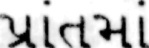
પ્રાંતમાં
